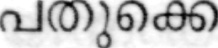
പതുക്കെ
